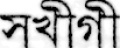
সখীগী
